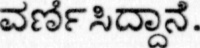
ವರ್ಣಿಸಿದ್ದಾನೆ.
